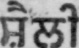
ਸ਼ੈਲੀ
